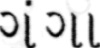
ગંગા
